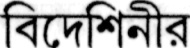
বিদেশিনীর
